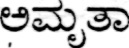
ಅಮೃತಾ
